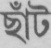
ছাঁট
